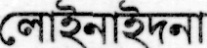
লোইনাইদনা
